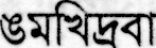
ঙমখিদ্রবা
